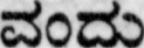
ವಂದು
